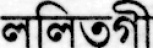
ললিতগী
